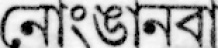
নোংঙানবা
